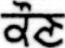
ਕੌਣ
